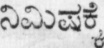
ನಿಮಿಷಕ್ಕೆ
